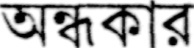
অন্ধকার
